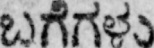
ಬಗೆಗಳು
